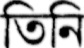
তিনি
